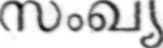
സംഖ്യ
